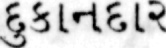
દુકાનદાર
